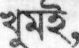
খুমই,
